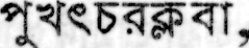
পুখৎচরক্লবা,
